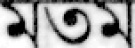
মতম
